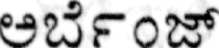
ಅರ್ಬೆಂಜ್
